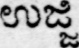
ಉಜ್ಜಿ
